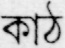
কাঠ
